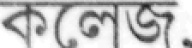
কলেজ,
